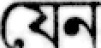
যেন
